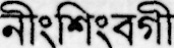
নীংশিংবগী
